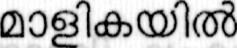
മാളികയില്‍
